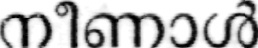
നീണാള്‍
